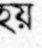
হয়
